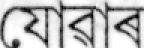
যোৱাৰ
